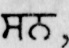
ਸਨ,
